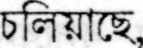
চলিয়াছে,
